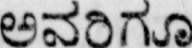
ಅವರಿಗೂ
